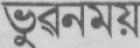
ভুৱনময়
